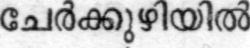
ചേര്‍ക്കുഴിയില്‍
